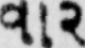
વાર
